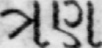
ત્રણ
